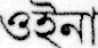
ওইনা
